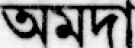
অমদা
